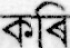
কৰি
